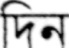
দিন
